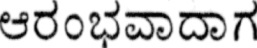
ಆರಂಭವಾದಾಗ
